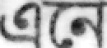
এনে
